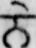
ਨੇ
